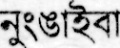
নুংঙাইবা
